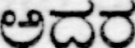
ಅದರ
